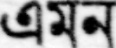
এমন
